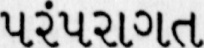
પરંપરાગત
